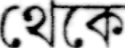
থেকে
